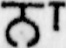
ਨਾ
